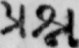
પ્રશ્ન
